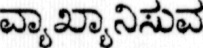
ವ್ಯಾಖ್ಯಾನಿಸುವ
